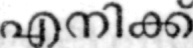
എനിക്ക്
